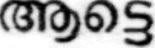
ആട്ടെ
